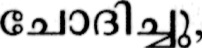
ചോദിച്ചു,
